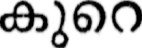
കുറെ
